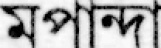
মপান্দা
